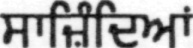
ਸਾਜ਼ਿੰਦਿਆਂ
